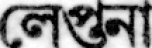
লেপ্তনা
